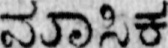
ಮಾಸಿಕ
